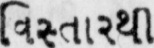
વિસ્તારથી
